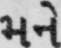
મને
